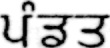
ਪੰਡਤ
